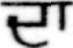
ਦਾ
